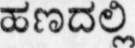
ಹಣದಲ್ಲಿ
